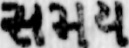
સમય
